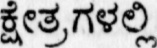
ಕ್ಷೇತ್ರಗಳಲ್ಲಿ
